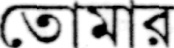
তোমার
